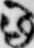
છે
